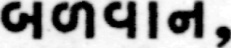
બળવાન,
